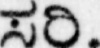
ಸರಿ.
